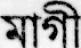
মাগী
